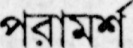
পরামর্শ
